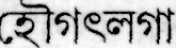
হৌগৎলগা
